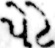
પેટે
